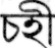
চহী
